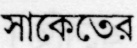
সাকেতের
